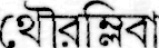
থৌরম্লিবা
